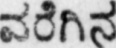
ವರೆಗಿನ
